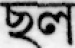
ছল
